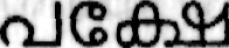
പക്ഷേ
